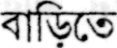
বাড়িতে
